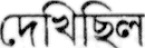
দেখিছিল
